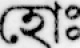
হোঃ
